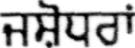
ਜਸ਼ੋਧਰਾਂ
